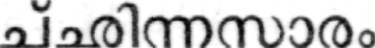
ച്ഛിന്നസാരം
